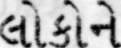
લોકોને
